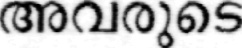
അവരുടെ
